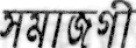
সমাজগী
